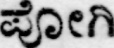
ಪೋಗಿ
